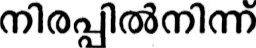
നിരപ്പില്‍നിന്ന്
